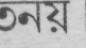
তনয়
